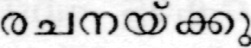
രചനയ്ക്കു
